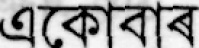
একোবাৰ
